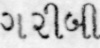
ગરીબી
